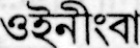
ওইনীংবা
